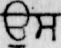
ਉਸ
